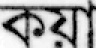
কয়া
